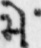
મેં
